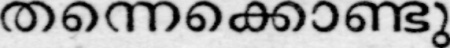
തന്നെക്കൊണ്ടു
